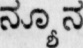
ನ್ಯೂನ
